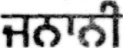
ਜਨਾਨੀ
